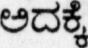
ಅದಕ್ಕೆ
